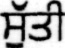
ਸੁੱਤੀ
